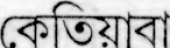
কেতিয়াবা
